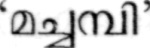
'മച്ചമ്പി'
